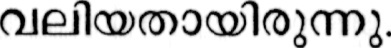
വലിയതായിരുന്നു.
